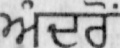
ਅੰਦਰੋਂ
